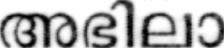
അഭിലാ
